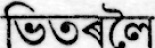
ভিতৰলৈ
